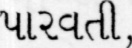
પારવતી,
